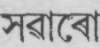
সৱাৰো
